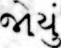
જોયું
